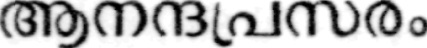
ആനന്ദപ്രസരം
